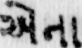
એના
